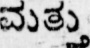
ಮತ್ತು
